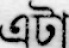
এটা
